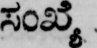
ಸಂಖ್ಯೆ
